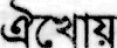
ঐখোয়
